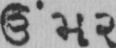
ઉંમર
